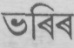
ভৰিৰ
